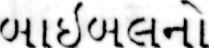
બાઈબલનો
